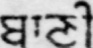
ਬਾਣੀ
